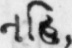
નહિ,
